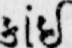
કાંઈ
